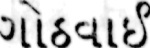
ગોઠવાઈ
